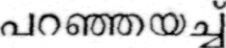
പറഞ്ഞയച്ച്
